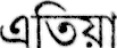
এতিয়া
